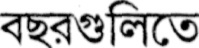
বছরগুলিতে
